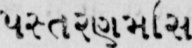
પસ્તરણમસિ
